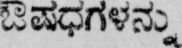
ಔಷಧಗಳನ್ನು
